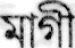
মাগী
